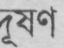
দূষণ
